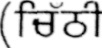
(ਚਿੱਠੀ
